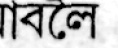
যাবলৈ
